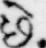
છે.
